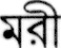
মরী
